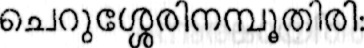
ചെറുശ്ശേരിനമ്പൂതിരി:
